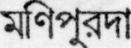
মণিপুরদা
